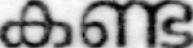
കണ്ട
